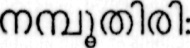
നമ്പൂതിരി:
